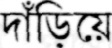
দাঁড়িয়ে
